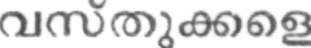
വസ്തുക്കളെ
